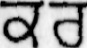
ਕਰ
